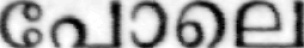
പോലെ
